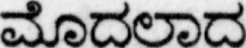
ಮೊದಲಾದ
